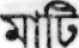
মাটি
